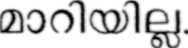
മാറിയില്ല.
